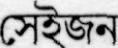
সেইজন
